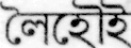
লৈহৌই
